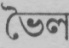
ভৈল
